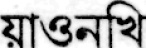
য়াওনখি
